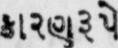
કારણરૂપે
